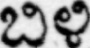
ಬಿಳಿ
